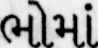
ભોમાં
